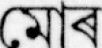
মোৰ
